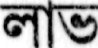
লাভ
